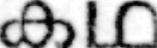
കഥ
